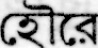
হৌরে
